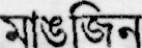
মাঙজিন
